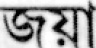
জয়া
